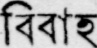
বিবাহ
